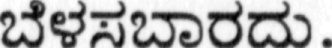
ಬೆಳೆಸಬಾರದು.
